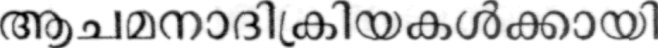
ആചമനാദിക്രിയകള്‍ക്കായി
